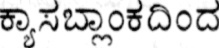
ಕ್ಯಾಸಬ್ಲಾಂಕದಿಂದ
